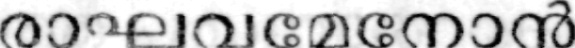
രാഘവമേനോന്‍
